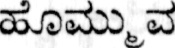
ಹೊಮ್ಮುವ
